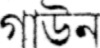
গাউন
